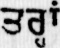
ਤਰ੍ਹਾਂ
